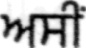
ਅਸੀਂ
